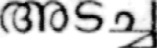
അടച്ച
